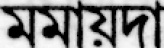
মমায়দা
